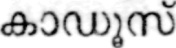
കാഡൂസ്
